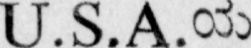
U.S.A.ಯ
